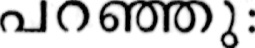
പറഞ്ഞു:
